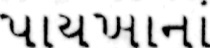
પાયખાનાં
